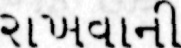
રાખવાની
